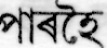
পাৰহৈ
